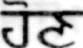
ਹੋਣ
